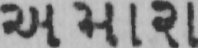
અમારા
